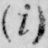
(i)
